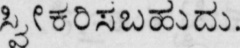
ಸ್ವೀಕರಿಸಬಹುದು.
